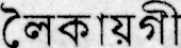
লৈকায়গী
